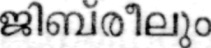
ജിബ്രീലും
